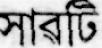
সাৱটি
